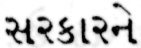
સરકારને
